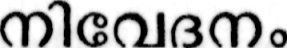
നിവേദനം
